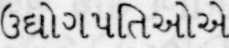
ઉદ્યોગપતિઓએ
